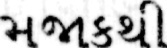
મજાકથી
